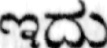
ಇದು
